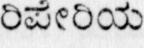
ರಿಪೇರಿಯ
